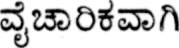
ವೈಚಾರಿಕವಾಗಿ
